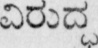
ವಿರುದ್ಧ
